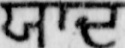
ਯਾਦ
